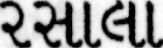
રસાલા
